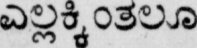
ಎಲ್ಲಕ್ಕಿಂತಲೂ
